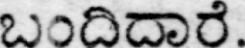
ಬಂದಿದಾರೆ.
